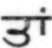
ਤਾਂ
